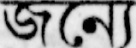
জন্যে
